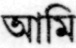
আমি
